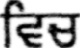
ਵਿਚ
